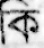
কি
